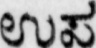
ಉಪ
